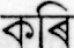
কৰি
